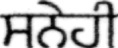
ਸਨੇਹੀ
